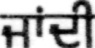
ਜਾਂਦੀ
